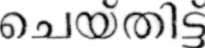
ചെയ്തിട്ട്
